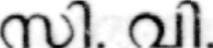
സി.വി.
